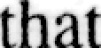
that
